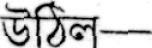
উঠিল-
